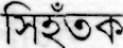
সিহঁতক
